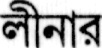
লীনার
